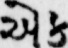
એક
